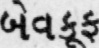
બેવકૂફ
